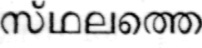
സ്ഥലത്തെ
